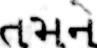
તમને
